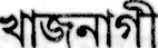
খাজনাগী
